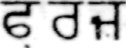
ਫ਼ਰਜ਼
